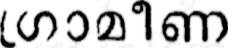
ഗ്രാമീണ
